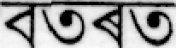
বতৰত
